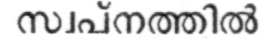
സ്വപ്നത്തില്‍
